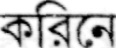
করিনে
